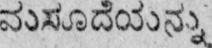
ಮಸೂದೆಯನ್ನು
